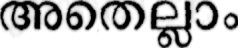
അതെല്ലാം
